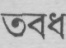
তবধ
